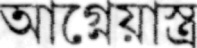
আগ্নেয়াস্ত্র
